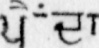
ਪੈਂਦਾ
